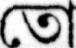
তো
